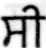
ਸੀ
